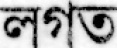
লগত
